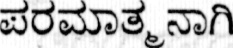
ಪರಮಾತ್ಮನಾಗಿ
